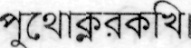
পুথোক্নরকখি।
